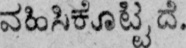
ವಹಿಸಿಕೊಟ್ಟಿದೆ.
